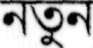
নতুন
